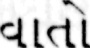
વાતો
